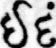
ઈદં
